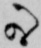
જે
